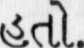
હતો.
